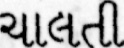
ચાલતી
